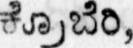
ಕ್ರೊಬೆರಿ,
